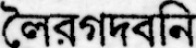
লৈরগদবনি
